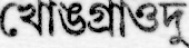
খোঙখ্রাওদু
